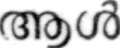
ആള്‍
